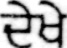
ਦੇਖੇ
